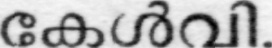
കേള്‍വി.
